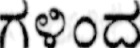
ಗಳಿಂದ
